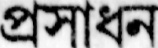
প্রসাধন
